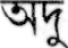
অদু
